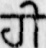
ਹੀ
